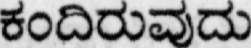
ಕಂದಿರುವುದು
